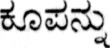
ಕೂಪನ್ನು
